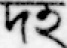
দহ
